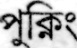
পুক্নিং
